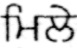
ਮਿਲੇ
